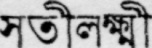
সতীলক্ষ্মী
